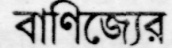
বাণিজ্যের
